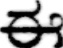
ಈ
